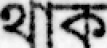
থাক
